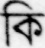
কি
